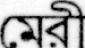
মেরী
